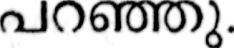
പറഞ്ഞു.
